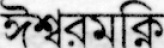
ঈশ্বরমক্নি
